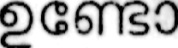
ഉണ്ടോ
